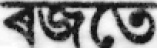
ৰজতে
